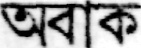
অবাক
